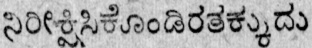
ನಿರೀಕ್ಷಿಸಿಕೊಂಡಿರತಕ್ಕುದು
